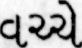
વચ્ચે
